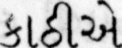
કાઠીએ
